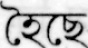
হৈছে
